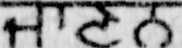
ਜਾਣਨ
